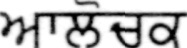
ਆਲੋਚਕ
